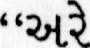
"અરે
